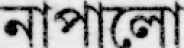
নাপালো
